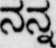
ನನ್ನ
